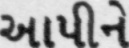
આપીને
